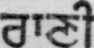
ਰਾਣੀ
